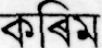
কৰিম
